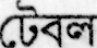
টেবল
